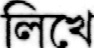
লিখে
